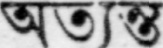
অত্যন্ত
